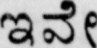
ಇವೇ
